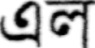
এল
